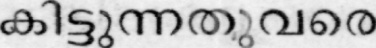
കിട്ടുന്നതുവരെ
